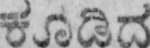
ಕೂಡಿದ
